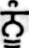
ਨੂੰ
